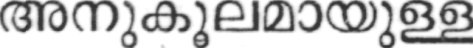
അനുകൂലമായുള്ള
